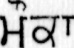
ਮੌਕਾ
